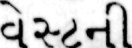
વેસ્ટની
